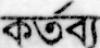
কর্তব্য
